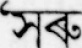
'সৰু
